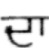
ਦਾ
